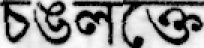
চঙলক্তে
